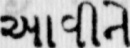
આવીને
